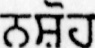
ਨਸ਼ੋਹ
